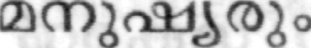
മനുഷ്യരും
